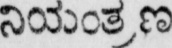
ನಿಯಂತ್ರಣ
